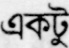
একটু
